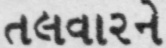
તલવારને
